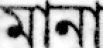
মানা
